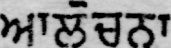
ਆਲੋਚਨਾ
